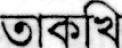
তাকখি
